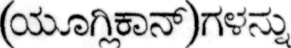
(ಯೂಗ್ಲಿಕಾನ್)ಗಳನ್ನು
